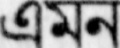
এমন
